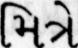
મિત્રે
